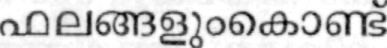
ഫലങ്ങളുംകൊണ്ട്
